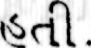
હતી.
